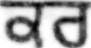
ਕਰ
